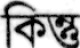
কিন্তু
